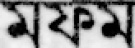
মফম
